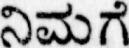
ನಿಮಗೆ
